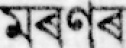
মৰণৰ
